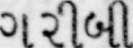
ગરીબી
